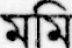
মমি
